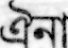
ঐনা
